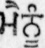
ਮੈਨੂੰ
